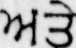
ਅਤੇ
